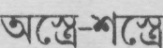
অস্ত্ৰে-শস্ত্ৰে
